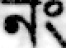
নং
